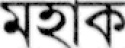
মহাক
